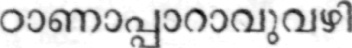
ഠാണാപ്പാറാവുവഴി
